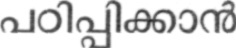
പഠിപ്പിക്കാന്‍
